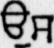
ਉਸ
